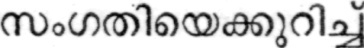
സംഗതിയെക്കുറിച്ച്
